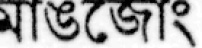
মাঙজোং
